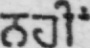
ਨਹੀਂ
